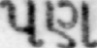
પણ
